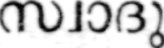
സ്വാദു
